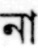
না
